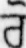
ਰੋ
